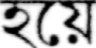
হয়ে
